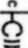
ਨੂੰ
